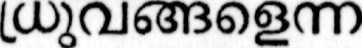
ധ്രുവങ്ങളെന്ന
